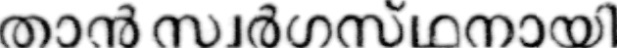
താന്‍സ്വര്‍ഗസ്ഥനായി
